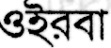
ওইরবা
